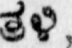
ತಳಿ,
